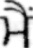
ਮੈਂ
